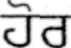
ਹੋਰ
